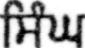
ਸਿੰਘ
